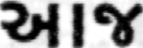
આજ
